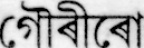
গৌৰীৰো
